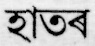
হাতৰ
